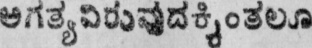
ಅಗತ್ಯವಿರುವುದಕ್ಕಿಂತಲೂ
